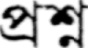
প্রশ্ন
